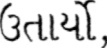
ઉતાર્યો,
